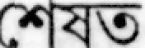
শেষত
